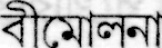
বীমোলনা
